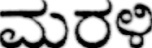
ಮರಳಿ
